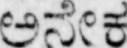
ಅನೇಕ
